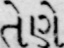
તેણે
